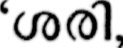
‘ശരി,
